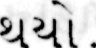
થયો.
